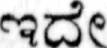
ಇದೇ
